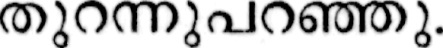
തുറന്നുപറഞ്ഞു.
